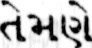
તેમણે
